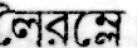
লৈরম্লে
